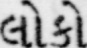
લોકો
